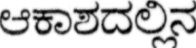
ಆಕಾಶದಲ್ಲಿನ
